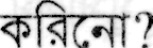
করিনো?
